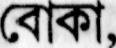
বোকা,
